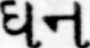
ધન
